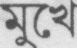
মুখে
